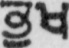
ਭੁਖ
